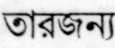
তারজন্য
